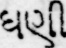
ઘણી
